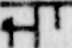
ਜਾ
